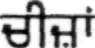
ਚੀਜ਼ਾਂ
